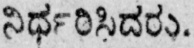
ನಿರ್ಧರಿಸಿದರು.
